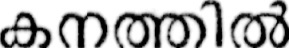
കനത്തില്‍
